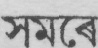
সমৰে
